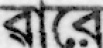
ৱারে
